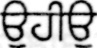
ਉਹੀਉ
